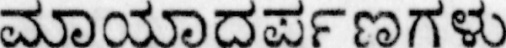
ಮಾಯಾದರ್ಪಣಗಳು
